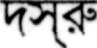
দস্রু
